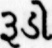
રૂડો
